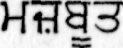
ਮਜ਼ਬੂਤ
